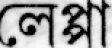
লেপ্পা
